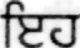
ਇਹ
